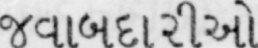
જવાબદારીઓ
